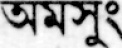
অমসুং
